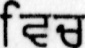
ਵਿਚ
